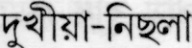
দুখীয়া-নিছলা
